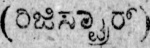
(ರಿಜಿಸ್ಟ್ರಾರ್)
